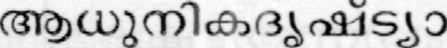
ആധുനികദൃഷ്ട്യാ
